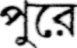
পুরে
